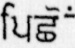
ਪਿਛੋਂ
